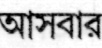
আসবার
